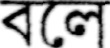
বলে
